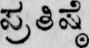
ಪ್ರತಿಷ್ಠೆ
